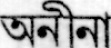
অনীনা
